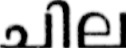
ചില
